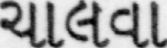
ચાલવા
